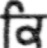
ਕਿ
